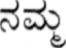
ನಮ್ಮ
